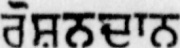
ਰੋਸ਼ਨਦਾਨ
